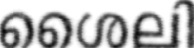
ശൈലി
